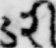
ડરી
